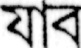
যাব
